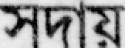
সদায়
